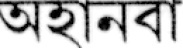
অহানবা
